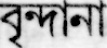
বৃন্দানা
